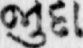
જુદા
